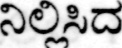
ನಿಲ್ಲಿಸಿದ
